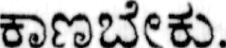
ಕಾಣಬೇಕು.
